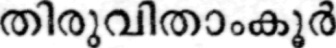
തിരുവിതാംകൂര്‍
